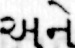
અને
